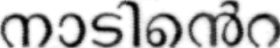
നാടിന്റെ
